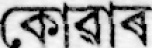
কোৱাৰ
